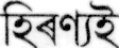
হিৰণ্যই
